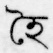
হৈ
